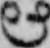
ಆ
